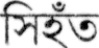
সিহঁত
